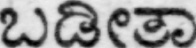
ಬಡೀತಾ
